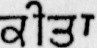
ਕੀਤਾ
